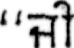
''ਜੀ
